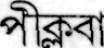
পীক্লবা
